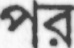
পর
